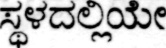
ಸ್ಥಳದಲ್ಲಿಯೇ
